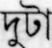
দুটা
